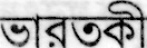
ভারতকী
